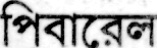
পিবারেল
